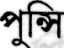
পুন্সি
